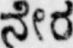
ನೇರ
